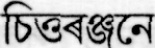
চিত্তৰঞ্জনে
